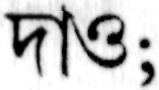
দাও;
